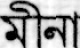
মীনা
